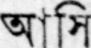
আসি
